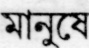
মানুষে
